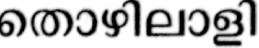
തൊഴിലാളി
